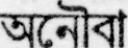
অনৌবা
